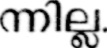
ന്നില്ല.
